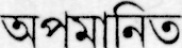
অপমানিত
